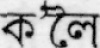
ক'লৈ
